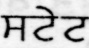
ਸਟੇਟ
